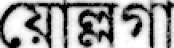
য়োল্লগা
